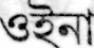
ওইনা
